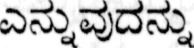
ಎನ್ನುವುದನ್ನು
